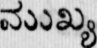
ಮುಖ್ಯ
